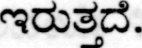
ಇರುತ್ತದೆ.
